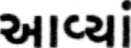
આવ્યાં
